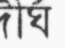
দীর্ঘ
